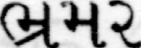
ભ્રમર
